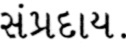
સંપ્રદાય.
